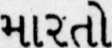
મારતો
